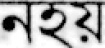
নহয়
